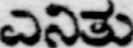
ಎನಿತು
